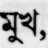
মুখ,
